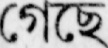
গেছে
